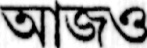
আজও
